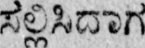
ಸಲ್ಲಿಸಿದಾಗ
